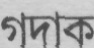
গদাক
